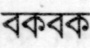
বকবক
